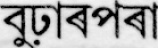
বুঢ়াৰপৰা
